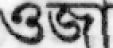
ওজা
